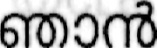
ഞാന്‍
